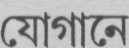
যোগানে
